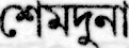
শেমদুনা
